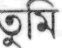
তুমি
